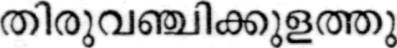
തിരുവഞ്ചിക്കുളത്തു
